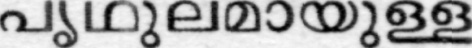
പൃഥുലമായുള്ള
